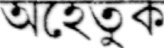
অহেতুক
